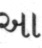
આ
